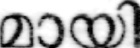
മായി
